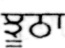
ਝੂਠਾ
